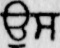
ਉਸ
